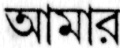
আমার
